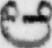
ಆ
